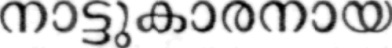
നാട്ടുകാരനായ
